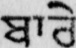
ਬਾਰੇ
